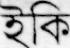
ইকি
